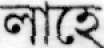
লাহে
